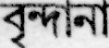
বৃন্দানা
